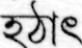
হঠাৎ
